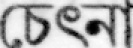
চেৎনা
